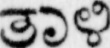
ತಾಳಿ
